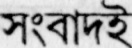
সংবাদই
